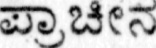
ಪ್ರಾಚೀನ
